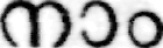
നാം
